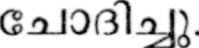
ചോദിച്ചു.
